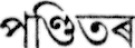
পণ্ডিতৰ
